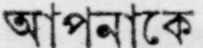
আপনাকে
